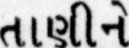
તાણીને
